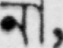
না,
